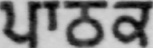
ਪਾਠਕ
